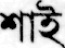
শাই
